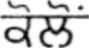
ਕੋਲੋਂ
